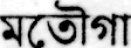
মতৌগা
